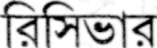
রিসিভার
